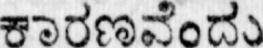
ಕಾರಣವೆಂದು
